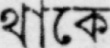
থাকে
